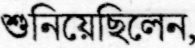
শুনিয়েছিলেন,
